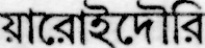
য়ারোইদৌরি
